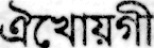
ঐখোয়গী
